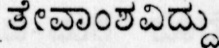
ತೇವಾಂಶವಿದ್ದು
